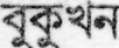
বুকুখন
